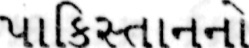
પાકિસ્તાનનો
